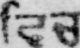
ਵਿਚ
